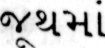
જૂથમાં
